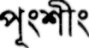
পূংশীং
